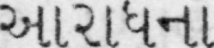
આરાધના
